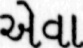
એવા
